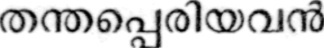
തന്തപ്പെരിയവന്‍
